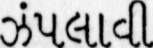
ઝંપલાવી
